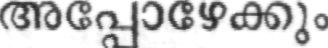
അപ്പോഴേക്കും
